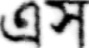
এস
